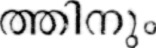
ത്തിനും
